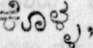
ಕೊಳ್ಳ,
